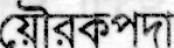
য়ৌরকপদা
